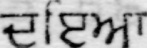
ਦਇਆ
